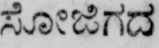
ಸೋಜಿಗದ
